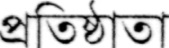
প্রতিষ্ঠাতা
